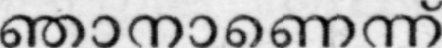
ഞാനാണെന്ന്
